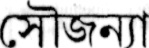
সৌজন্যা
